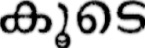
കൂടെ
